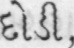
દોડી,
